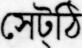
সেট্ঠি
